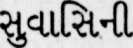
સુવાસિની
